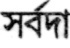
সর্বদা
